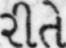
રીતે
